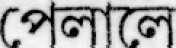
পেলালে
